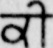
ਕੀ
